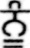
ਨੂੰ
